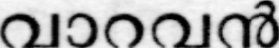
വാറവന്‍
